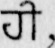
ਹੀ,
